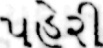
પહેરી
